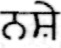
ਨਸ਼ੇ
